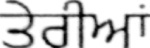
ਤੇਰੀਆਂ
